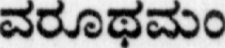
ವರೂಥಮಂ
